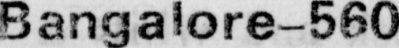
Bangalore-560
